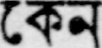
কেন
